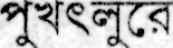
পুখৎলুরে
